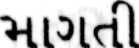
માગતી
